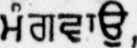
ਮੰਗਵਾਉ,
